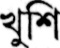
খুশি
